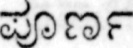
ಪೂರ್ಣ
